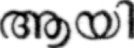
ആയി
